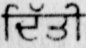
ਦਿੱਤੀ
